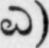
ಎ)
